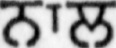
ਨਾਲ
